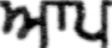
ਆਪ
